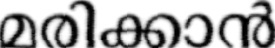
മരിക്കാന്‍
